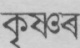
কৃষ্ণৰ
